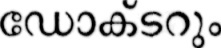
ഡോക്ടറും
